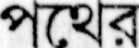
পথের
